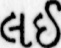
લઈ
